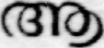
ആ
